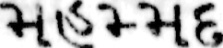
મહમ્મદ
